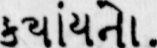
ક્યાંયનો.
